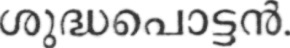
ശുദ്ധപൊട്ടന്‍.
